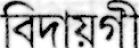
বিদায়গী
